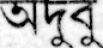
অদুবু
